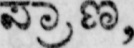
ಪ್ರಾಣ,
